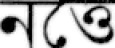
নত্তে
